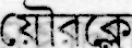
য়ৌরক্লে
